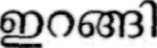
ഇറങ്ങി
